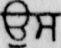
ਉਸ
